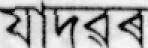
যাদৱৰ
